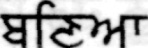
ਬਣਿਆ
